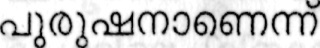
പുരുഷനാണെന്ന്
